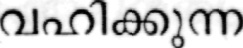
വഹിക്കുന്ന
